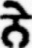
ਨੇ
